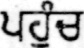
ਪਹੁੰਚ
